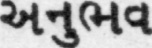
અનુભવ
